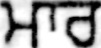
ਮਾਰ
